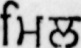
ਮਿਲ
